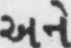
અને
